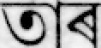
তাৰ
